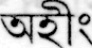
অহীং
